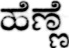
ಹೆಣ್ಣೆ
